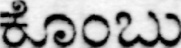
ಕೊಂಬು
